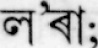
ল'ৰা;
